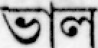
ভাল
